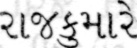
રાજકુમારે
